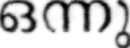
ഒന്നു
